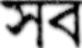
সব
